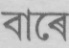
বাৰে
